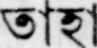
তাহা
